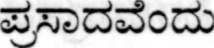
ಪ್ರಸಾದವೆಂದು
